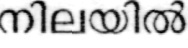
നിലയില്‍
